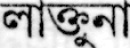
লাক্তুনা
